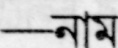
–নাম
